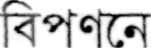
বিপণনে
